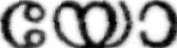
യോ
